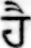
ਹੈ
